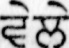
ਵੇਲੇ
